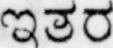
ಇತರ
